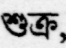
শুক্র,
